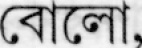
বোলো,
